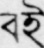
বই
